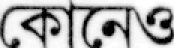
কোনেও
